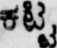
ಕಟ್ಟಿ
